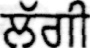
ਲੱਗੀ
